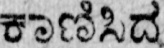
ಕಾಣಿಸಿದ
